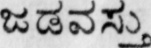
ಜಡವಸ್ತು
